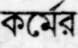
কর্মের
